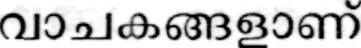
വാചകങ്ങളാണ്
